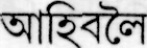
আহিবলৈ
